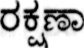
ರಕ್ಷಣಾ
